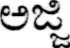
ಅಜ್ಜಿ
